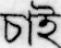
চাই
